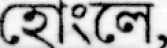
হোংলে,
